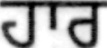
ਹਾਰ
